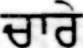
ਚਾਰੇ
